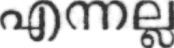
എന്നല്ല
